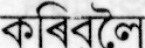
কৰিবলৈ
